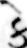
કે
